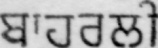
ਬਾਹਰਲੀ
